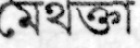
মৈথক্তা
